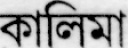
কালিমা
